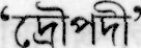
‘দ্রৌপদী’
